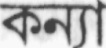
কন্যা
